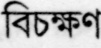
বিচক্ষণ
